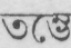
তম্ভে
